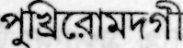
পুখ্রিরোমদগী
